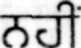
ਨਹੀਂ
